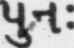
પુનઃ
